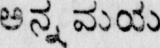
ಅನ್ನಮಯ
